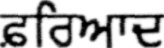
ਫ਼ਰਿਆਦ
